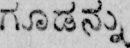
ಗೂಡನ್ನು
